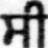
ਸੀ
